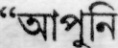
"আপুনি
